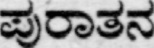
ಪುರಾತನ
